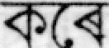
কৰে
